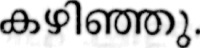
കഴിഞ്ഞു.
